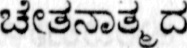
ಚೇತನಾತ್ಮದ
